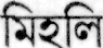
মিহলি
